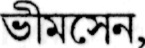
ভীমসেন,
